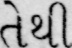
તેથી
